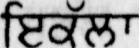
ਇਕੱਲਾ
